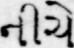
નીચે
